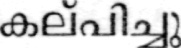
കല്പിച്ചു
